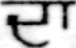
ਦਾ
